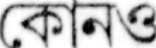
কোনও
